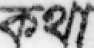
কথা
